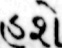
હશે
